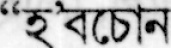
"হ'বচোন
